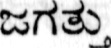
ಜಗತ್ತು
